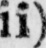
ii)
